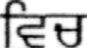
ਵਿਚ
